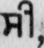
ਸੀ,
